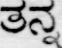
ತನ್ನ
